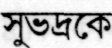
সুভদ্রকে
